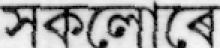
সকলোৰে
